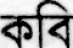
কবি
